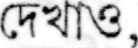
দেখাও,
